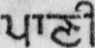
ਪਾਣੀ
